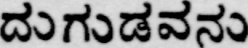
ದುಗುಡವನು
